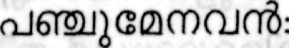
പഞ്ചുമേനവന്‍:
